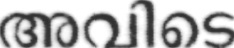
അവിടെ
